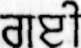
ਗਈ
